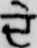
ਦੇ
